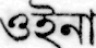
ওইনা
